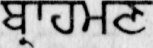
ਬ੍ਰਾਹਮਣ
